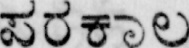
ಪರಕಾಲ
